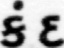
કંદ
